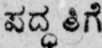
ಪದ್ಧತಿಗೆ
